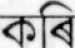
কৰি
